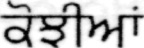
ਕੋਝੀਆਂ
